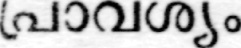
പ്രാവശ്യം
